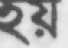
হয়
